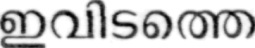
ഇവിടത്തെ
